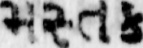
મસ્તક
